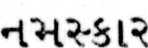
નમસ્કાર
